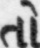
તો
